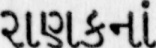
રાણકનાં
